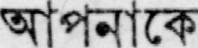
আপনাকে
